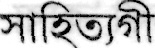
সাহিত্যগী
